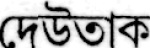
দেউতাক
